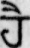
ਹੈ
